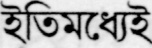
ইতিমধ্যেই
